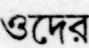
ওদের
